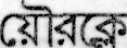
য়ৌরক্লে
